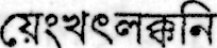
য়েংখৎলক্কনি
